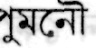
পুমনৌ
